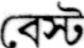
বেস্ট
